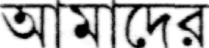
আমাদের
